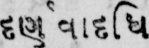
દર્ણવાદધિ
